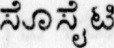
ಸೊಸೈಟಿ
